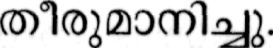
തീരുമാനിച്ചു.
